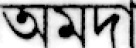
অমদা
